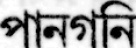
পানগনি
